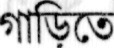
গাড়িতে
